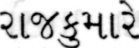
રાજકુમારે
